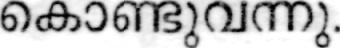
കൊണ്ടുവന്നു.
